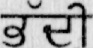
ਭੱਦੀ
